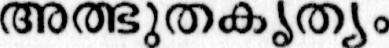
അത്ഭുതകൃത്യം
